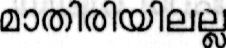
മാതിരിയിലല്ല
